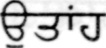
ਉਤਾਂਹ
